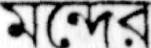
মন্দের
